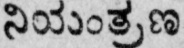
ನಿಯಂತ್ರಣ
